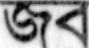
জব
